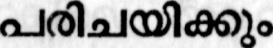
പരിചയിക്കും
